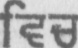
ਵਿਚ
